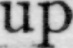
up
